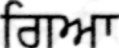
ਗਿਆ
